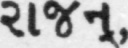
રાજન્,
